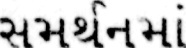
સમર્થનમાં
